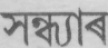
সন্ধ্যাৰ
